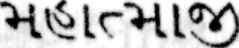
મહાત્માજી
